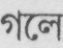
গলে
